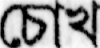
চোখ
